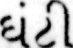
ઘંટી
